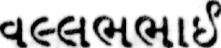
વલ્લભભાઈ
